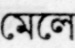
মেলে
